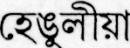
হেঙুলীয়া
